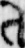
તે
